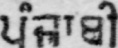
ਪੰਜਾਬੀ
